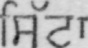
ਸਿੱਟਾ
